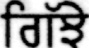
ਗਿੱਝੇ
